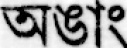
অঙাং
